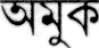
অমু্ক
